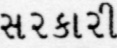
સરકારી
